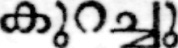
കുറച്ചു
